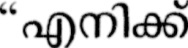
“എനിക്ക്
